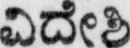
ವಿದೇಶಿ
